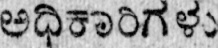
ಅಧಿಕಾರಿಗಳು
